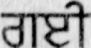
ਗਈ
